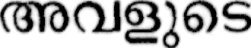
അവളുടെ
